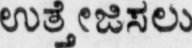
ಉತ್ತೇಜಿಸಲು
